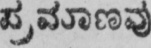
ಪ್ರಮಾಣವು
